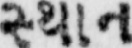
સ્થાન
